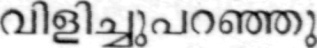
വിളിച്ചുപറഞ്ഞു
